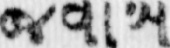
જવાબ
